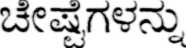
ಚೇಷ್ಟೆಗಳನ್ನು
